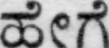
ಹೇಗೆ
